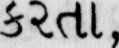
કરતા,
